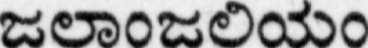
ಜಲಾಂಜಲಿಯಂ
